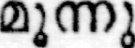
മൂന്നു
